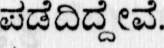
ಪಡೆದಿದ್ದೇವೆ.
